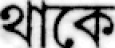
থাকে
